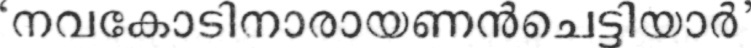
'നവകോടിനാരായണന്‍ചെട്ടിയാര്‍'
